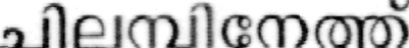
ചിലമ്പിനേത്ത്
